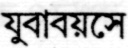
যুবাবয়সে
